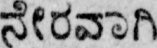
ನೇರವಾಗಿ
